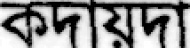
কদায়দা
